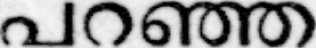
പറഞ്ഞ
